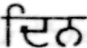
ਦਿਨ
